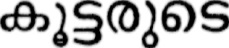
കൂട്ടരുടെ
